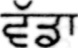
ਵੱਡਾ
